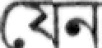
যেন
